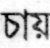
চায়
